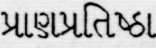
પ્રાણપ્રતિષ્ઠા
